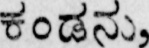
ಕಂಡನು,
